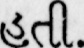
હતી.
